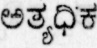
ಅತ್ಯಧಿಕ
